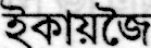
ইকায়জৈ
